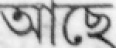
আছে
